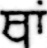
ਥਾਂ
